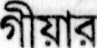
গীয়ার
